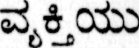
ವ್ಯಕ್ತಿಯು
